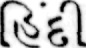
હિંદી
